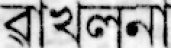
ৱাখলনা
